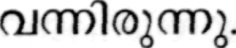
വന്നിരുന്നു.
